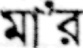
মা’র
